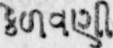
કેળવણી
